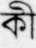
কী
